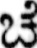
ಚೆ
